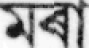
মৰা
